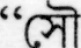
"সৌ
